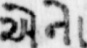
એનો
